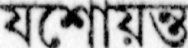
যশোয়ন্ত
